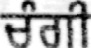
ਚੰਗੀ
